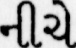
નીચે
